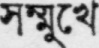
সম্মুখে
